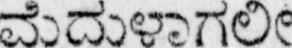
ಮೆದುಳಾಗಲೀ
